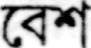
বেশ
